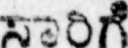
ಸಾರಿಗೆ
